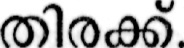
തിരക്ക്.
